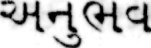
અનુભવ
